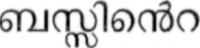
ബസ്സിന്റെ
